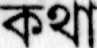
কথা
